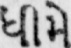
ધીમે
